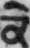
ਕੇ
